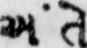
અંતે
